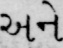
અને
